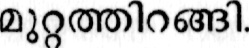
മുറ്റത്തിറങ്ങി.
